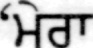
'ਮੇਰਾ
